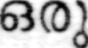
ഒരു
